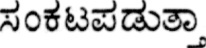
ಸಂಕಟಪಡುತ್ತಾ
